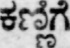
ಕಣ್ಣಿಗೆ
